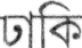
ঢাকি
